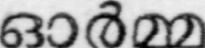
ഓര്‍മ്മ
